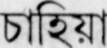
চাহিয়া
